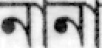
নানা
